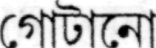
গোটানো
